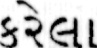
કરેલા
